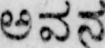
ಅವನ
